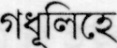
গধূলিহে
